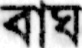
বাঘ
